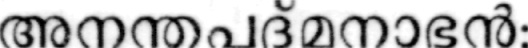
അനന്തപദ്മനാഭന്‍:
